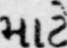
માટે
